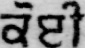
ਕੋਈ
